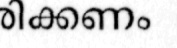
രിക്കണം.
